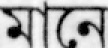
মানে
